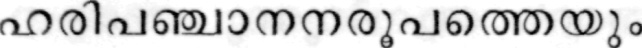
ഹരിപഞ്ചാനനരൂപത്തെയും
